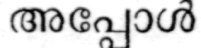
അപ്പോള്‍
